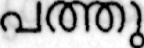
പത്തു
